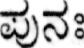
ಪುನಃ
